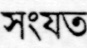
সংযত
